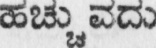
ಹಚ್ಚುವದು
